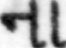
ના
